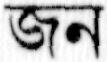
জন
